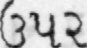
ઉપર
